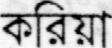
করিয়া
